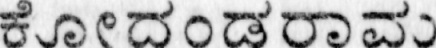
ಕೋದಂಡರಾಮ
